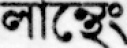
লান্থেং
